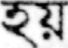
হয়
